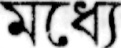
মধ্যে
